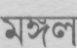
মঙ্গল
